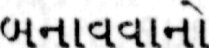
બનાવવાનો
